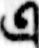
এ
